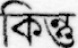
কিন্তু
